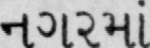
નગરમાં
